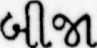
બીજા
